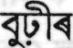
বুঢ়ীৰ
